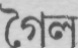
গৈল
